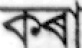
কৰা
